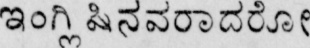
ಇಂಗ್ಲಿಷಿನವರಾದರೋ
